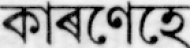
কাৰণেহে
